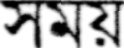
সময়
